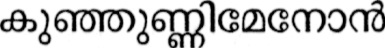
കുഞ്ഞുണ്ണിമേനോന്‍
